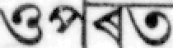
ওপৰত
